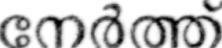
നേര്‍ത്ത്
